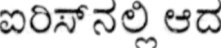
ಐರಿಸ್ನಲ್ಲಿಆದ
